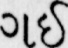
ગઈ
